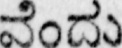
ವೆಂದು
